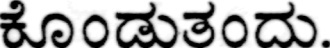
ಕೊಂಡುತಂದು.
